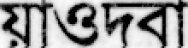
য়াওদবা
